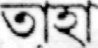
তাহা
